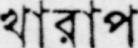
খারাপ
